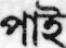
পাই
